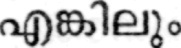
എങ്കിലും
